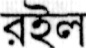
রইল
